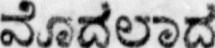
ಮೊದಲಾದ
